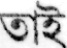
তাই
